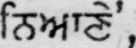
ਨਿਆਣੇ',
